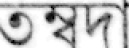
তম্বদা
